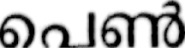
പെണ്‍
